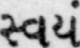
સ્વયં
